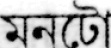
মনটো
